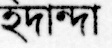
হিদান্দা
